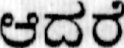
ಆದರೆ
